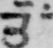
ਤੋਂ
